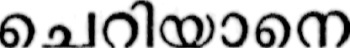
ചെറിയാനെ
